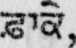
ਫ਼ਾਕੇ,
